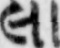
લા
